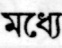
মধ্যে
